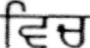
ਵਿਚ
